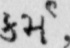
કર્મ,
